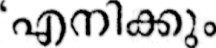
‘എനിക്കും
